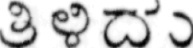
ತಿಳಿದು
